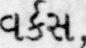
વર્કસ,
